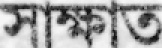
সাক্ষাত
